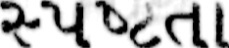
સ્પષ્ટતા
